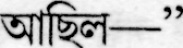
আছিল-"
